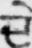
ਦੇ
